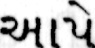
આપે
